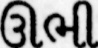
ઊભી
